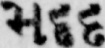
મદદ
